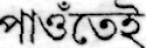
পাওঁতেই
